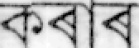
কৰাৰ
